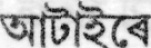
আটাইৰে
